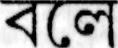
বলে
